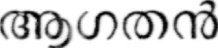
ആഗതന്‍
